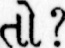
તો?
